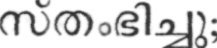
സ്തംഭിച്ചു;
